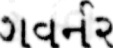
ગવર્નર
